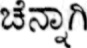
ಚೆನ್ನಾಗಿ
